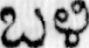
ಬಳಿ
